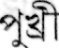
পুখ্রী
